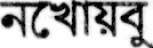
নখোয়বু
